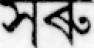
সৰু
